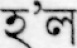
হ'ল
